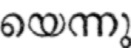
യെന്നു
